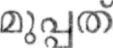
മുപ്പത്
